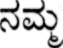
ನಮ್ಮ
